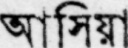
আসিয়া
